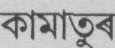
কামাতুৰ
